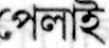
পেলাই
